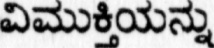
ವಿಮುಕ್ತಿಯನ್ನು
